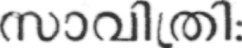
സാവിത്രി:
